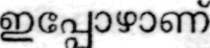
ഇപ്പോഴാണ്
